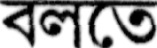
বলতে
